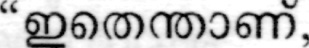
“ഇതെന്താണ്,
